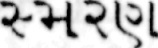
સ્મરણ
